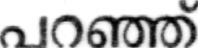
പറഞ്ഞ്
